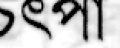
চৎপা
